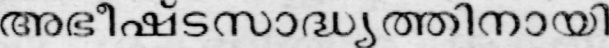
അഭീഷ്ടസാദ്ധ്യത്തിനായി
